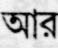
আর
